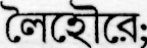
লৈহৌরে;
